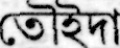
তৌইদা
